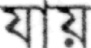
যায়
